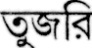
তুজরি
